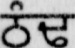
ਠੰਢ
